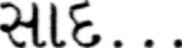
સાદ...
